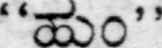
“ಹು೦”
